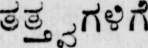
ತತ್ತ್ವಗಳಿಗೆ
